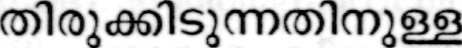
തിരുക്കിടുന്നതിനുള്ള
